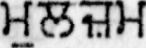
ਮੁਲਜ਼ਮ
